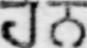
ਹਨ
